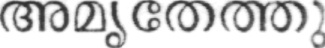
അമൃതേത്തു
